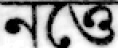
নত্তে
